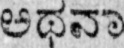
ಅಥವಾ
